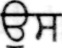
ਉਸ
